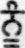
ਨੂੰ
